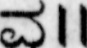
ವ||
